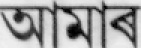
আমাৰ
